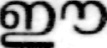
ഈ
